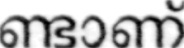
ണ്ടാണ്
